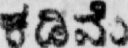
ಕಡಿಮೆ
